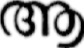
ആ
